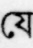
যে
